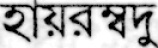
হায়রম্বদু
